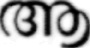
ആ
